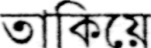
তাকিয়ে
